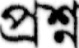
প্রশ্ন
